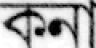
কনা
